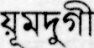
য়ূমদুগী
